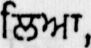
ਲਿਆ,
